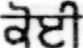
ਕੋਈ
